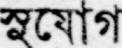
সুযোগ
